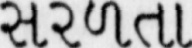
સરળતા
